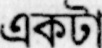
একটা
